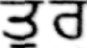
ਤੁਰ
